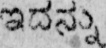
ಇದನ್ನು
